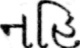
નહિ
